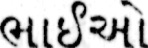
ભાઈઓ
